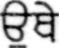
ਉਥੇ
